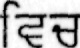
ਵਿਚ
